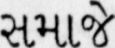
સમાજે
